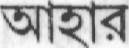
আহার
